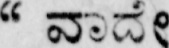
“ವಾದೇ
